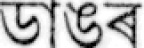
ডাঙৰ
